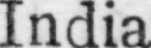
India
